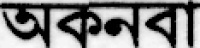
অকনবা
